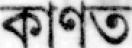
কাণত
